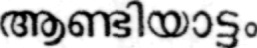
ആണ്ടിയാട്ടം
